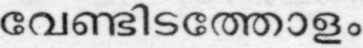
വേണ്ടിടത്തോളം
